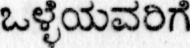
ಒಳ್ಳೆಯವರಿಗೆ
